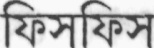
ফিসফিস
